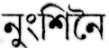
নুংশিনৈ
